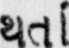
થતાં
